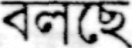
বলছে
